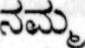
ನಮ್ಮ
